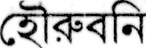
হৌরুবনি
